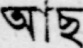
আছ
